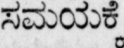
ಸಮಯಕ್ಕೆ
